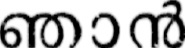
ഞാന്‍
